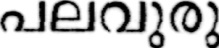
പലവുരു
